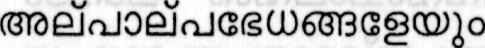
അല്പാല്പഭേധങ്ങളേയും
